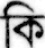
কি
